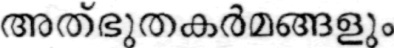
അത്ഭുതകര്‍മങ്ങളും
